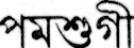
পমশুগী
